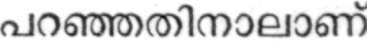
പറഞ്ഞതിനാലാണ്
